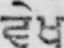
ਵੇਖ
